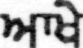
ਆਖੇ
